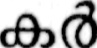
കര്‍
